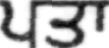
ਪਤਾ
